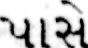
પાસે
